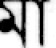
মা
